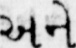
અને
